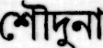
শৌদুনা
